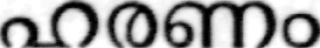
ഹരണം
